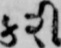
કરી
